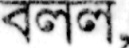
বলল,
